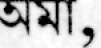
অমা,
